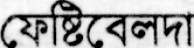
ফেষ্টেবেলদা
